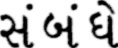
સંબંધે
